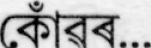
কোঁৱৰ...
